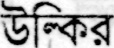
উল্কির
